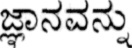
ಜ್ಞಾನವನ್ನು
